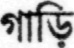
গাড়ি
